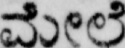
ಮೇಲೆ
